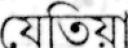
যেতিয়া
